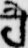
ਹੈ
